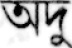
অদু
